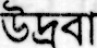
উদ্রবা
